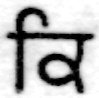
ਕਿ
